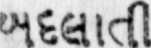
બદલાતી
